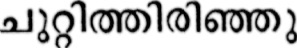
ചുറ്റിത്തിരിഞ്ഞു
